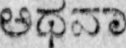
ಅಥವಾ
